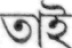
তাই
